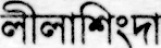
লীলাশিংদা
